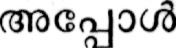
അപ്പോള്‍
